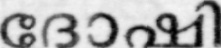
ദോഷി
